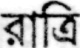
রাত্রি
